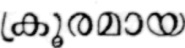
ക്രൂരമായ
